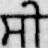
ਸੀ
